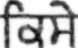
ਕਿਸੇ
